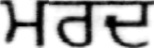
ਮਰਦ
